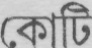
কোটি
